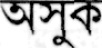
অসুক
